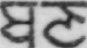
ਬਣ
